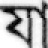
যা
